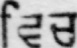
ਵਿਚ
